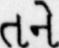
તને
